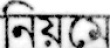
নিয়মে
